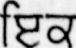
ਇਕ
